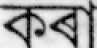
কৰা
